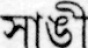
সাঙী
